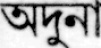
অদুনা
